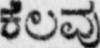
ಕೆಲವು
